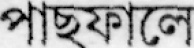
পাছফালে
